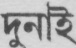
দুনাই
